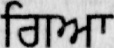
ਗਿਆ
